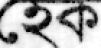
হেক
